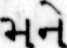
મને
